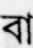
বা
